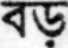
বড়
